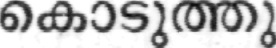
കൊടുത്തു
